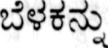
ಬೆಳಕನ್ನು
